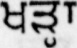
ਖੜ੍ਹਾ
